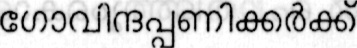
ഗോവിന്ദപ്പണിക്കര്‍ക്ക്
